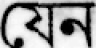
যেন
